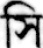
সি
